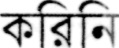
করিনি
